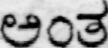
ಅಂತ
